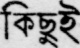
কিছুই
